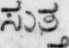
ಸುತ್ತ
